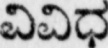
ವಿವಿಧ
